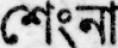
শেংনা
